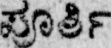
ಪೂರ್ತಿ
